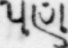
પણ
